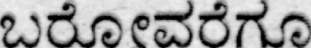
ಬರೋವರೆಗೂ
